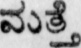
ಮತ್ತೆ
